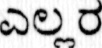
ಎಲ್ಲರ
